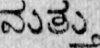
ಮತ್ತು
